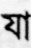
যা
